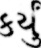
કર્યું
